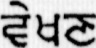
ਵੇਖਣ
